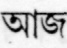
আজ
